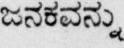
ಜನಕವನ್ನು
